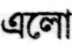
এলো
